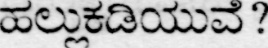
ಹಲ್ಲುಕಡಿಯುವೆ?
